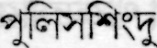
পুলিসশিংদু
